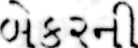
બેકરની
